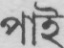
পাই
